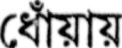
ধোঁয়ায়
